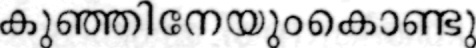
കുഞ്ഞിനേയുംകൊണ്ടു
